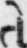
તે
